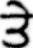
ਤੇ
